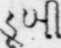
ડૂબી
